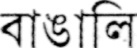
বাঙালি
